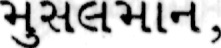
મુસલમાન,
